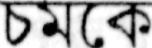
চমকে
